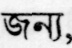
জন্য,
